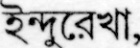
ইন্দুরেখা,
